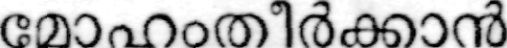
മോഹംതീര്‍ക്കാന്‍
